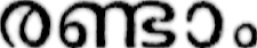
രണ്ടാം
